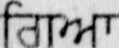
ਗਿਆ
